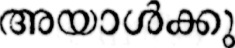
അയാള്‍ക്കു
